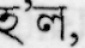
হ'ল,
